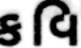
કવિ
